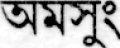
অমসুং
